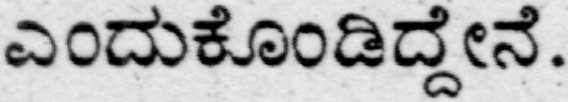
ಎಂದುಕೊಂಡಿದ್ದೇನೆ.
